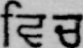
ਵਿਚ
